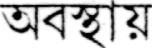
অবস্থায়
